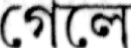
গেলে
